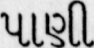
પાણી
